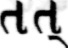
તત્
